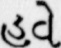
હવે
